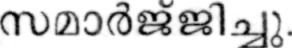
സമാര്‍ജ്ജിച്ചു.
